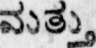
ಮತ್ತು
